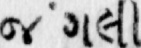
જંગલી
